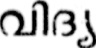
വിദ്യ
